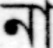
না
